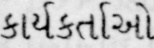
કાર્યકર્તાઓ
